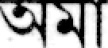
অমা
